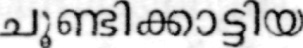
ചൂണ്ടിക്കാട്ടിയ
